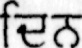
ਦਿਨ
